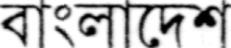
বাংলাদেশ
